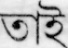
তাই
